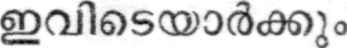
ഇവിടെയാര്‍ക്കും
